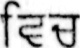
ਵਿਚ
